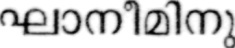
ഘാനീമിനു
